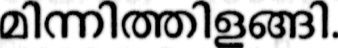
മിന്നിത്തിളങ്ങി.
